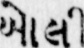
બોલી
